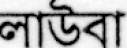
লাউবা
